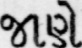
જાણે
